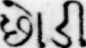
છોડી
